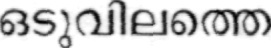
ഒടുവിലത്തെ
